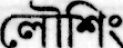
লৌশিং
